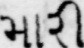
મારી
